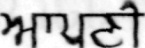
ਆਪਣੀ
